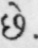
છે.
